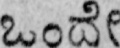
ಒಂದೇ
